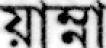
য়াম্না
